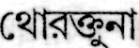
থোরক্তুনা
